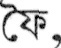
ফৈ,
